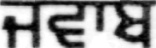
ਜਵਾਬ
